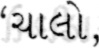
'ચાલો,
